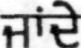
ਜਾਂਦੇ
